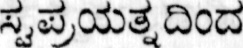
ಸ್ವಪ್ರಯತ್ನದಿಂದ
